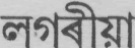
লগৰীয়া
